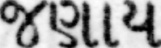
જણાય
